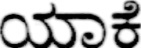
ಯಾಕೆ
